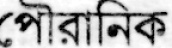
পৌরানিক
